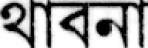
থাবনা
